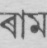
ৰাম
